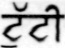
ਟੁੱਟੀ
